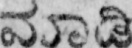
ಮಾಡಿ
